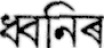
ধ্বনিৰ
